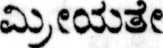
ಮ್ರೀಯತೇ
